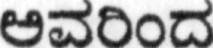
ಅವರಿಂದ
